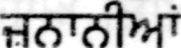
ਜ਼ਨਾਨੀਆਂ
